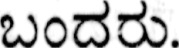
ಬಂದರು.
